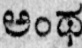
ಅಂಥ
